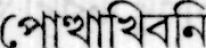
পোত্থাখিবনি
